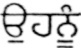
ਉਹਨੂੰ
